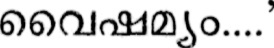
വൈഷമ്യം....'
